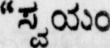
“ಸ್ವಯಂ
